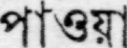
পাওয়া
